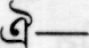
ঐ-
